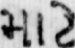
માટે
